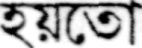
হয়তো
